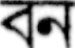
বন
